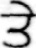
ਤੇ
